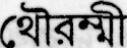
থৌরম্মী
